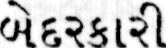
બેદરકારી
